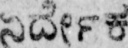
ನಿರ್ದೇಕ
